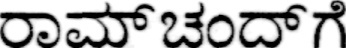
ರಾಮ್ಚಂದ್ಗೆ
